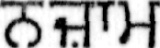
ਨਜ਼ਾਮ
